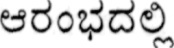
ಆರಂಭದಲ್ಲಿ
